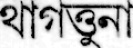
থাগত্তুনা
